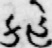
કહે
